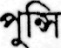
পুন্সি
